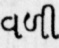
વળી
